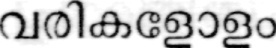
വരികളോളം
